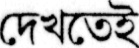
দেখতেই
